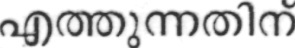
എത്തുന്നതിന്
